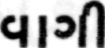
વાગી
